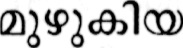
മുഴുകിയ
